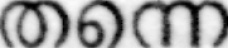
തന്നെ
